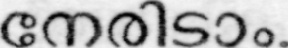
നേരിടാം.
